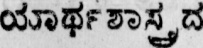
ಯಾರ್ಥಶಾಸ್ತ್ರದ
